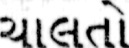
ચાલતો
